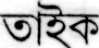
তাইক
